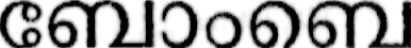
ബോംബെ
